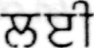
ਲਈ
